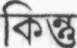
কিন্তু
